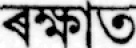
ৰক্ষাত
